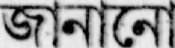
জানানো
